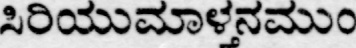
ಸಿರಿಯುಮಾಳ್ತನಮುಂ
